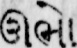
ઊભો
